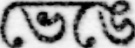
ভেঙে
